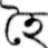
হৈ
